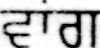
ਵਾਂਗ
